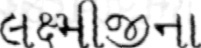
લક્ષ્મીજીના
